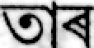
তাৰ
